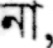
না,
